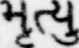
મૃત્યુ
